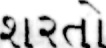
શરતો
